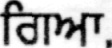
ਗਿਆ,
